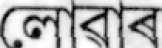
লোৱাৰ
